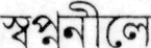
স্বপ্ননীলে
